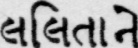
લલિતાને
